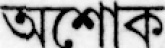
অশোক
